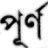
পূর্ণ
